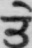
ਤੇ
